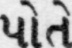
પોતે
